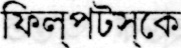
ফিল্‌পটস্‌কে
